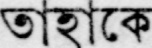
তাহাকে
